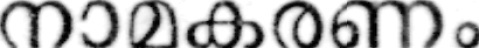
നാമകരണം
